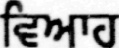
ਵਿਆਹ
